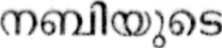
നബിയുടെ
